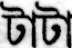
টাটা
